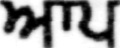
ਆਪ
